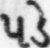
પડે
